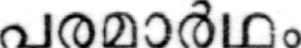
പരമാര്‍ഥം
